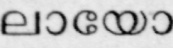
ലായോ
